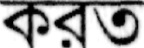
করত
